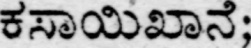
ಕಸಾಯಿಖಾನೆ;
